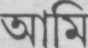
আমি
